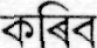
কৰিব
